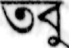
তবু
